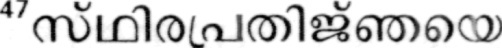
47സ്ഥിരപ്രതിജ് ഞയെ
